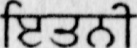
ਇਤਨੀ
